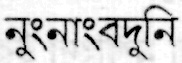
নুংনাংবদুনি
